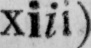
xiii)
